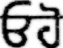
ਓਹੋ
